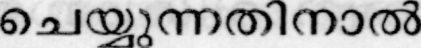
ചെയ്യുന്നതിനാല്‍
